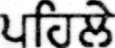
ਪਹਿਲੇ
